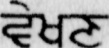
ਵੇਖਣ
